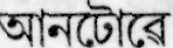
আনটোৱে
